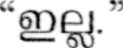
“ഇല്ല."
